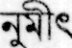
নুমীৎ
